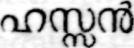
ഹസ്സന്‍
